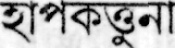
হাপকত্তুনা
